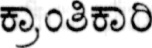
ಕ್ರಾಂತಿಕಾರಿ
